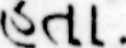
હતા.
